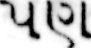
પણ
